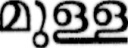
മുള്ള
